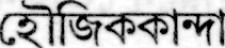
হৌজিককান্দা
